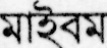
মাইবম
